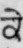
ਕੇ
